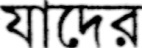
যাদের
